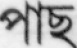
পাছ
